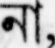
না,
